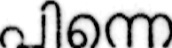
പിന്നെ
